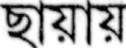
ছায়ায়
